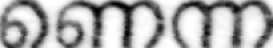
ണെന്ന
